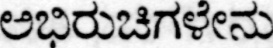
ಅಭಿರುಚಿಗಳೇನು
